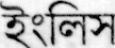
ইংলিস
